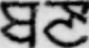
ਬਣ
